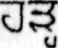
ਹੜ੍ਹ
